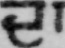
ਦਾ
